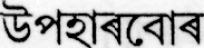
উপহাৰবোৰ
